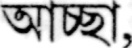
আচ্ছা,
